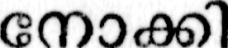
നോക്കി
